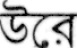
উরে
